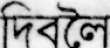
দিবলৈ
